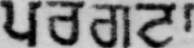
ਪਰਗਟਾ
